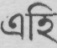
এহি
